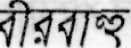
বীরবাহু
